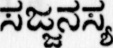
ಸಜ್ಜನಸ್ಯ
